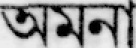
অমনা
